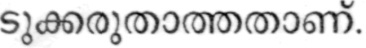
ടുക്കരുതാത്തതാണ്.
